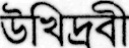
উখিদ্রবী
